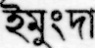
ইমুংদা
